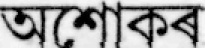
অশোকৰ
